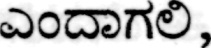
ಎಂದಾಗಲಿ,
